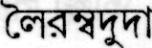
লৈরম্বদুদা
